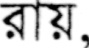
রায়,
